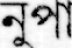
নুপা
